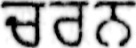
ਚਰਨ
